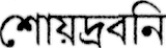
শোয়দ্রবনি
